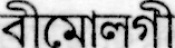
বীমোলগী
